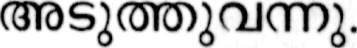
അടുത്തുവന്നു.
